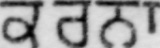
ਕਰਨਾ
